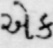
એક
